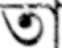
তা
